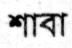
শাবা
